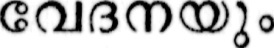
വേദനയും
